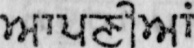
ਆਪਣੀਆਂ
